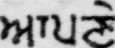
ਆਪਣੇ
